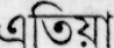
এতিয়া
